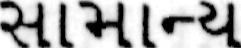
સામાન્ય
